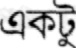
একটু
